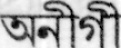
অনীগী
